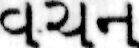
વચન
